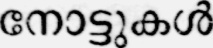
നോട്ടുകള്‍
